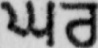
ਘਰ
